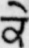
ਕੇ
